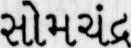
સોમચંદ્ર
